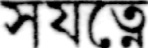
সযত্নে
